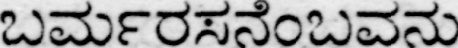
ಬರ್ಮರಸನೆಂಬವನು
